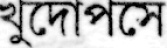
খুদোপসে
